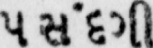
પસંદગી
